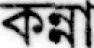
কন্না
